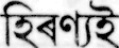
হিৰণ্যই
